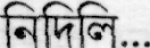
নিদিলি...
